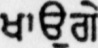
ਖਾਉਗੇ
